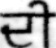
ਦੀ
